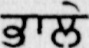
ਭਾਲੇ
